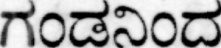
ಗಂಡನಿಂದ
